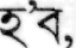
হ'ব,
